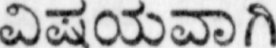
ವಿಷಯವಾಗಿ
